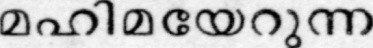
മഹിമയേറുന്ന
